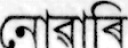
নোৱাৰি
